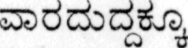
ವಾರದುದ್ದಕ್ಕೂ
